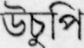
উচুপি
